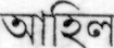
আহিল
